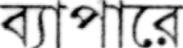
ব্যাপারে
